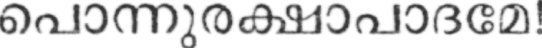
പൊന്നുരക്ഷാപാദമേ!
